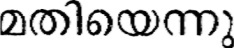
മതിയെന്നു
